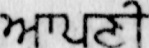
ਆਪਣੀ
